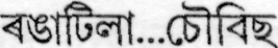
ৰঙাটিলা...চৌবিছ
